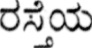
ರಸ್ತೆಯ
